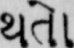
થતો
